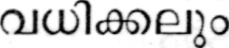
വധിക്കലും
